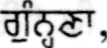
ਗੁੰਨ੍ਹਣਾ,
